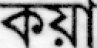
কয়া
